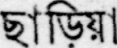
ছাড়িয়া
